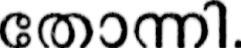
തോന്നി.
